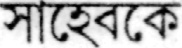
সাহেবকে
